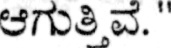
ಆಗುತ್ತಿವೆ.”
